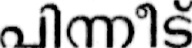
പിന്നീട്
